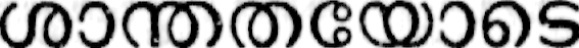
ശാന്തതയോടെ
